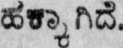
ಹಕ್ಕಾಗಿದೆ.
